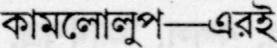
কামলোলুপ–এরই
